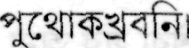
পুথোকখ্রবনি।
